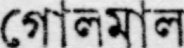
গোলমাল
